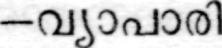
-വ്യാപാരി
